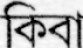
কিবা
